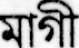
মাগী
